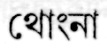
থোংনা
